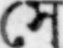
সে
